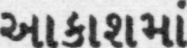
આકાશમાં
